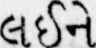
લઈને
